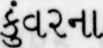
કુંવરના
